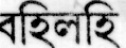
বহিলহি
